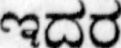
ಇದರ
